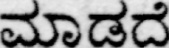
ಮಾಡದೆ
